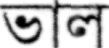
ভাল
